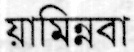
য়ামিন্নবা
